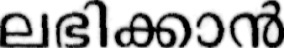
ലഭിക്കാന്‍
